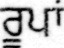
ਰੂਪਾਂ
